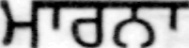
ਮਾਰਨਾ
